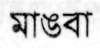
মাঙবা
